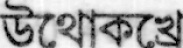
উথোকখ্রে
